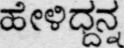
ಹೇಳಿದ್ದನ್ನ
